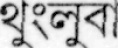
থুংলুবা
